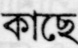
কাছে
